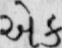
એક
